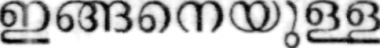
ഇങ്ങനെയുള്ള
